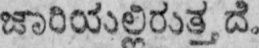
ಜಾರಿಯಲ್ಲಿರುತ್ತದೆ.
